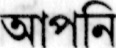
আপনি
